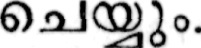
ചെയ്യും.
